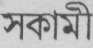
সকামী
